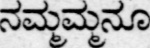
ನಮ್ಮಮ್ಮನೂ
